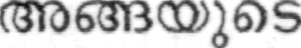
അങ്ങയുടെ
